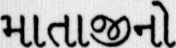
માતાજીનો
